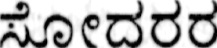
ಸೋದರರ
